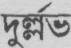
দুৰ্ল্লভ
